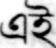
এই
